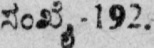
ಸಂಖ್ಯೆ-192.
